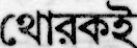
থোরকই
